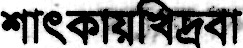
শাৎকায়খিদ্রবা
